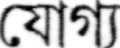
যোগ্য
